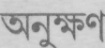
অনুক্ষণ
